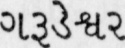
ગરૂડેશ્વર
